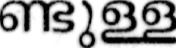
ണ്ടുള്ള
